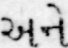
અને
